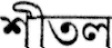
শীতল
